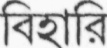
বিহারি
